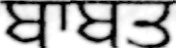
ਬਾਬਤ
